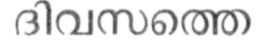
ദിവസത്തെ
